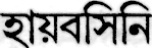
হায়বসিনি
